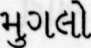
મુગલો
